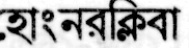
হোংনরক্লিবা
